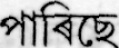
পাৰিছে
